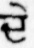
ਦੇ
